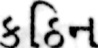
કઠિન
